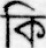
কি
